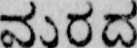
ಮರದ
